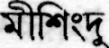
মীশিংদু
